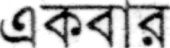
একবার
